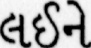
લઈને
